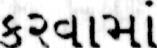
કરવામાં
